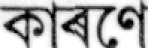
কাৰণে
